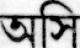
অসি
